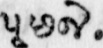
પૂછજે.
